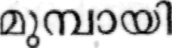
മുമ്പായി
